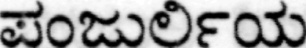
ಪಂಜುರ್ಲಿಯ
